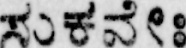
ಸುಕವೇಃ
